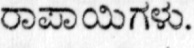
ರೂಪಾಯಿಗಳು.
